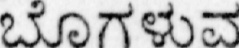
ಬೊಗಳುವ
